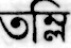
তম্লি
